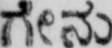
ಗೇನು
